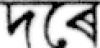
দৰে
